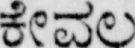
ಕೇವಲ
